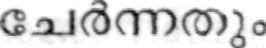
ചേര്‍ന്നതും
